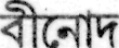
বীনোদ
